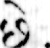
છે.
